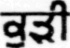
ਕੁੜੀ
